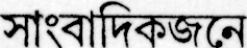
সাংবাদিকজনে
